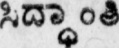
ಸಿದ್ದಾಂತಿ
